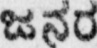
ಜನರ
